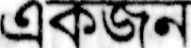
একজন
